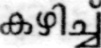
കഴിച്ച്
